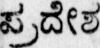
ಪ್ರದೇಶ
